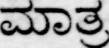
ಮಾತ್ರ
